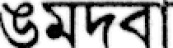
ঙমদবা
